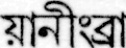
য়ানীংব্রা
